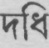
দধি
